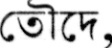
তৌদে,
